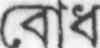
বোধ
